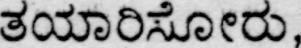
ತಯಾರಿಸೋರು,
